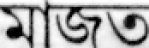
মাজত
